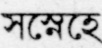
সস্নেহে
